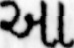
આ
